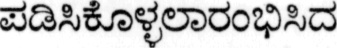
ಪಡಿಸಿಕೊಳ್ಳಲಾರಂಭಿಸಿದ
